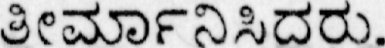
ತೀರ್ಮಾನಿಸಿದರು.
